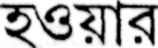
হওয়ার
